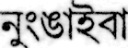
নুংঙাইবা
